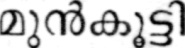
മുന്‍കൂട്ടി
